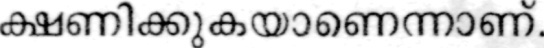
ക്ഷണിക്കുകയാണെന്നാണ്.
